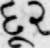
દૂર
